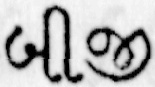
બીજી
